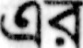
এর
